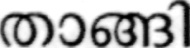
താങ്ങി
